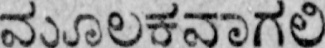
ಮೂಲಕವಾಗಲಿ
